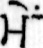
ਮੇਂ
